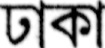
ঢাকা
